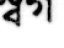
স্বর্গ
